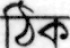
ঠিক
